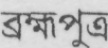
ব্রহ্মপুত্র
